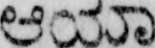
ಆಯಾ
